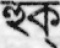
হুক্
